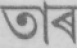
তাৰ
